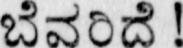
ಬೆವರಿದೆ!
